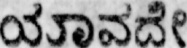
ಯಾವುದೇ
